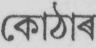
কোঠাৰ
